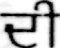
ਦੀ
